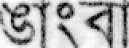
ঙাংবা
